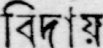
বিদায়
